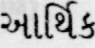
આર્થિક
